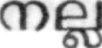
നല്ല
